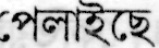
পেলাইছে
